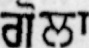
ਗੋਲਾ
